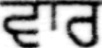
ਵਾਰ
